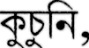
কুচুনি,
